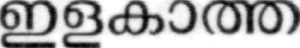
ഇളകാത്ത
